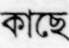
কাছে
